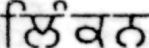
ਲਿੰਕਨ
